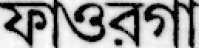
ফাওরগা
